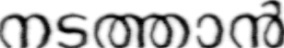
നടത്താന്‍
